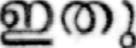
ഇതു
